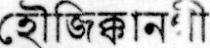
হৌজিক্কানগী
